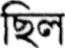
ছিল
